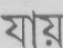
যায়
